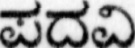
ಪದವಿ
